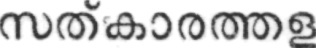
സത്കാരത്തള
